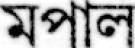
মপাল
